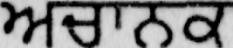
ਅਚਾਨਕ
